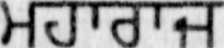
ਮਹਾਰਾਜ
